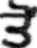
ਤੋਂ
